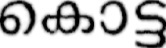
കൊട്ട
